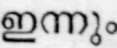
ഇന്നും
